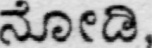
ನೋಡಿ,
